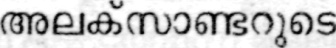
അലക്സാണ്ടറുടെ
